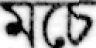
মচে
